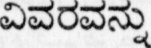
ವಿವರವನ್ನು
